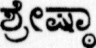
ಶ್ರೇಷ್ಠಾ
